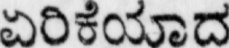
ಏರಿಕೆಯಾದ
